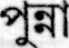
পুন্না
